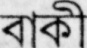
বাকী
